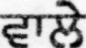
ਵਾਲੇ
